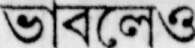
ভাবলেও
